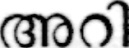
അറി
